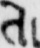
તો
